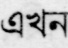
এখন
